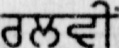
ਰਲਵੀਂ
